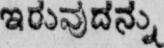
ಇರುವುದನ್ನು
